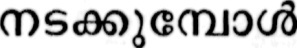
നടക്കുമ്പോള്‍
